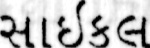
સાઈકલ
